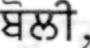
ਬੋਲੀ,
